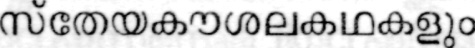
സ്തേയകൌശലകഥകളും
